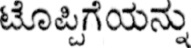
ದೊಪ್ಪಿಗೆಯನ್ನು
